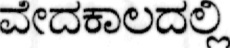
ವೇದಕಾಲದಲ್ಲಿ
